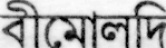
বীমোলদি
